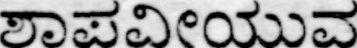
ಶಾಪವೀಯುವ
